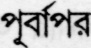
পূর্বাপর
